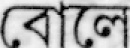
বোলে
